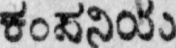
ಕಂಪನಿಯ
